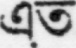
এত
